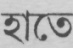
হাতে
